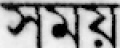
সময়
